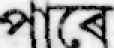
পাৰে
